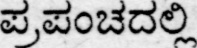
ಪ್ರಪಂಚದಲ್ಲಿ
